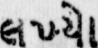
લખ્યો
